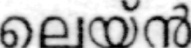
ലെയ്ന്‍
